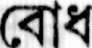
বোধ
